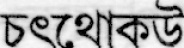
চৎথোকউ
